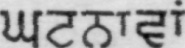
ਘਟਨਾਵਾਂ
